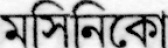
মসিনিকো
